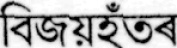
বিজয়হঁতৰ
